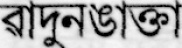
ৱাদুনঙাক্তা
